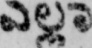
ಎಲ್ಲಾ
